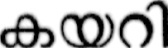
കയറി
